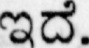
ಇದೆ.
